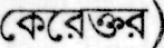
কেরেক্তর)
